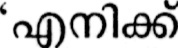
'എനിക്ക്
